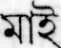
মাই
